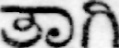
ತಾಗಿ
